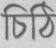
চিঠি
